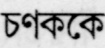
চণককে
